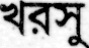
খরসু
